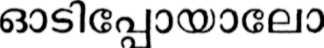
ഓടിപ്പോയാലോ
